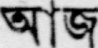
আজ
